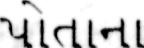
પોતાના
